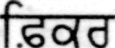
ਫ਼ਿਕਰ
